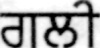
ਗਲੀ
